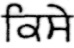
ਕਿਸੇ
